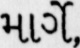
માર્ગે,
